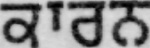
ਕਾਰਨ
